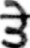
ਤੇ
